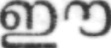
ഈ
